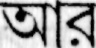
আর
